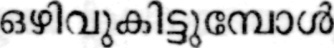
ഒഴിവുകിട്ടുമ്പോള്‍
